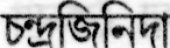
চন্দ্রজিনিদা
